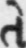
તે
